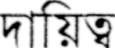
দায়িত্ব
